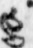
હું
